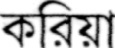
করিয়া
